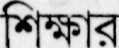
শিক্ষার
